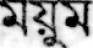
ময়ুম
